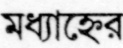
মধ্যাহ্নের
